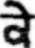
ਕੇ
